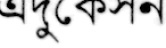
এদুকেসন
